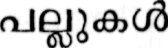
പല്ലുകള്‍
